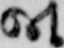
જા
